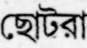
ছোটরা
